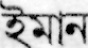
ইমান
